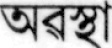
অৱস্হা
